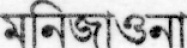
মনিজাওনা
